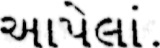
આપેલાં.
